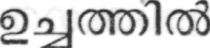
ഉച്ചത്തില്‍
